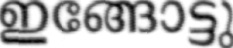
ഇങ്ങോട്ടു
